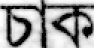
চাক
